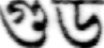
গুড
